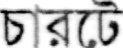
চারটে
